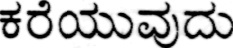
ಕರೆಯುವುದು
